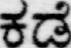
ಕಡೆ
